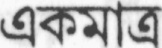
একমাত্র
